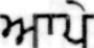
ਆਪੇ
